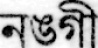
নঙগী
